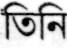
তিনি
